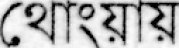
থোংয়ায়
